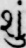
શું
